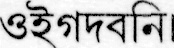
ওইগদবনি।
